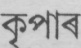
কৃপাৰ
